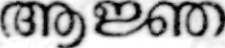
ആജ്ഞ
